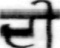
ਦੀ
